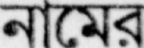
নামের
